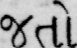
જતો
